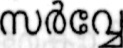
സര്‍വ്വേ
